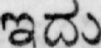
ಇದು
